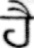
ਹੈ
